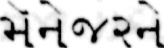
મૅનેજરને
